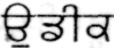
ਉਡੀਕ
